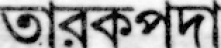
তারকপদা
